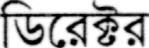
ডিরেক্টর
